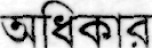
অধিকার
